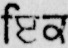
ਇਕ
